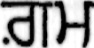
ਗ਼ਮ
